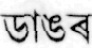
ডাঙৰ
